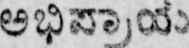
ಅಭಿಪ್ರಾಯ
